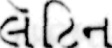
લૅટિન
